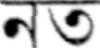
নত
